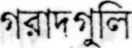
গরাদগুলি
